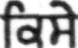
ਕਿਸੇ
